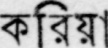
করিয়া
